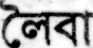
লৈবা
